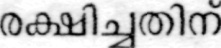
രക്ഷിച്ചതിന്
